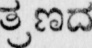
ತ್ರಣದ
